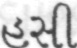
હસી
